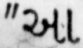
"આ
